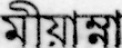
মীয়াম্না
